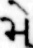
મે
